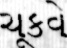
ચૂકવે
